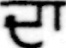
ਦਾ
